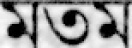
মতম
